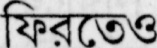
ফিরতেও
